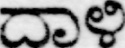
ದಾಳಿ
